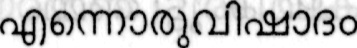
എന്നൊരുവിഷാദം
